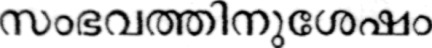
സംഭവത്തിനുശേഷം
